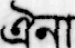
ঐনা
